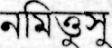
নমিত্তুসু
